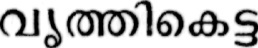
വൃത്തികെട്ട
